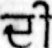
ਦੀ
